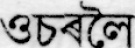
ওচৰলৈ
